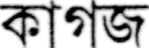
কাগজ
